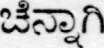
ಚೆನ್ನಾಗಿ
